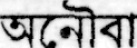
অনৌবা
